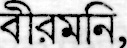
বীরমনি,
